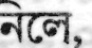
নিলে,
